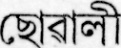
ছোৱালী
